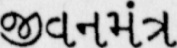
જીવનમંત્ર
